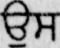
ਉਸ
